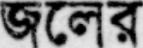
জলের
